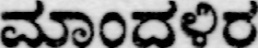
ಮಾಂದಳಿರ
